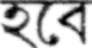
হবে
